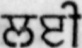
ਲਈ
